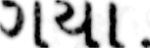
ગયા.
